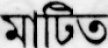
মাটিত
